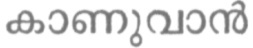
കാണുവാന്‍
